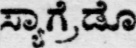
ಸ್ಯಾಗ್ರೆಡೊ
